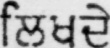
ਲਿਖਦੇ
